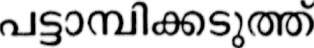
പട്ടാമ്പിക്കടുത്ത്
